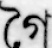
গৈ
